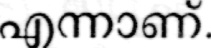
എന്നാണ്.
